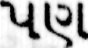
પણ
